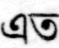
এত
